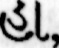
હા,
